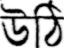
উঠি
